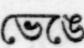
ভেঙে
